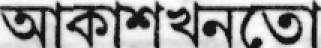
আকাশখনতো
